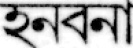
হনবনা
